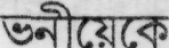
ভনীয়েকে
